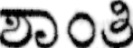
ಶಾಂತಿ
